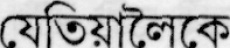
যেতিয়ালৈকে
